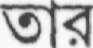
তার
